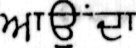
ਆਉਂਦਾ
